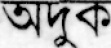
অদুক
